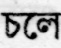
চলে
